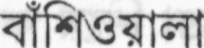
বাঁশিওয়ালা
